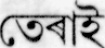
তেৰাই
